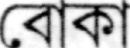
বোকা
